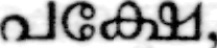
പക്ഷേ,
